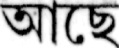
আছে
